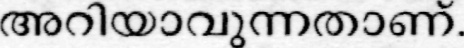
അറിയാവുന്നതാണ്.
